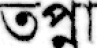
তপ্না
